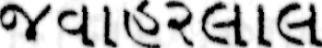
જવાહરલાલ
